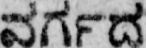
ವರ್ಗದ
